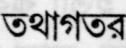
তথাগতর
